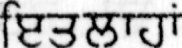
ਇਤਲਾਹਾਂ
